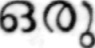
ഒരു
